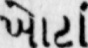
ખોટાં
